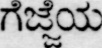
ಗೆಜ್ಜೆಯ
